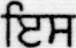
ਇਸ
